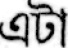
এটা
